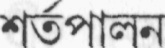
শর্তপালন
